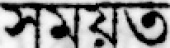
সময়ত
